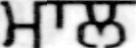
ਮਾਲ
